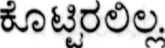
ಕೊಟ್ಟಿರಲಿಲ್ಲ.
